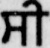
ਸੀ
